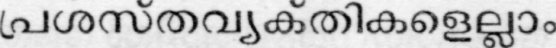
പ്രശസ്തവ്യക്തികളെല്ലാം
